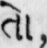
તો,
